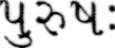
પુરુષઃ
